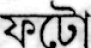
ফটো
